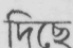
দিছে
